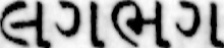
લગભગ
